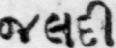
જલદી
